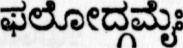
ಫಲೋದ್ಗಮೈಃ
